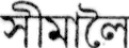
সীমালৈ
